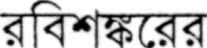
রবিশঙ্করের
